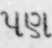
પણ
